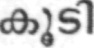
കൂടി
